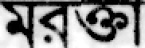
মরক্তা
